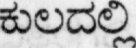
ಕುಲದಲ್ಲಿ
